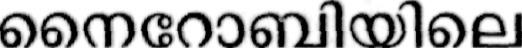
നൈറോബിയിലെ
